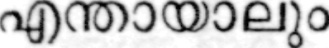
എന്തായാലും
